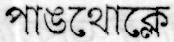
পাঙথোক্লে
